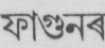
ফাগুনৰ
